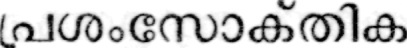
പ്രശംസോക്തിക
